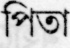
পিতা
